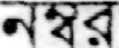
নম্বর
